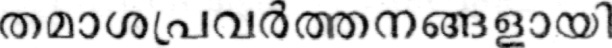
തമാശപ്രവര്‍ത്തനങ്ങളായി
